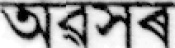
অৱসৰ
